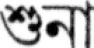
শুনা
